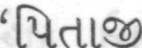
'પિતાજી
